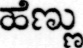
ಹೆಣ್ಣು
